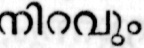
നിറവും
